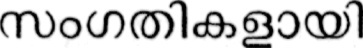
സംഗതികളായി
